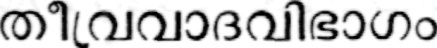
തീവ്രവാദവിഭാഗം
